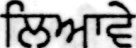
ਲਿਆਵੇ
